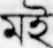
মই
